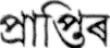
প্রাপ্তিৰ
